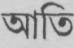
আতি
